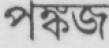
পঙ্কজ
